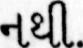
નથી.
